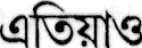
এতিয়াও
